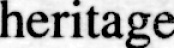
heritage
